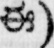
ಈ)
